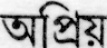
অপ্রিয়
